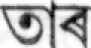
তাৰ
